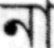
না
